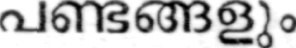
പണ്ടങ്ങളും
